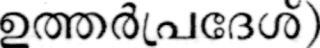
ഉത്തര്‍പ്രദേശ്)
